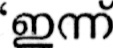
‘ഇന്ന്
